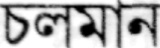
চলমান
